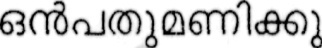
ഒന്‍പതുമണിക്കു
